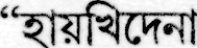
“হায়খিদেনা
